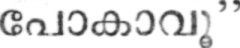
പോകാവൂ"
